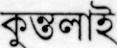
কুন্তলাই
